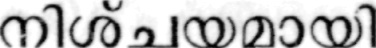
നിശ്ചയമായി
